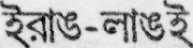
ইরাঙ-লাঙই
